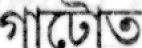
গাটোত
